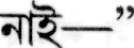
নাই-"
